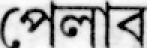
পেলাব
